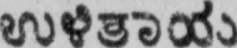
ಉಳಿತಾಯ
